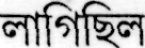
লাগিছিল
